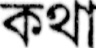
কথা
